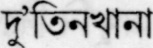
দু’তিনখানা
